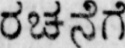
ರಚನೆಗೆ
